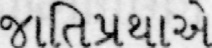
જાતિપ્રથાએ
